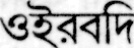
ওইরবদি
